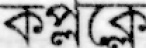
কপ্লক্লে
